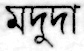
মদুদা
